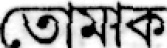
তোমাক
